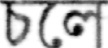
চলে
